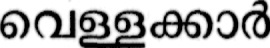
വെള്ളക്കാര്‍
